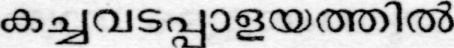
കച്ചവടപ്പാളയത്തില്‍
